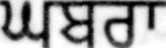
ਘਬਰਾ
